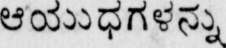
ಆಯುಧಗಳನ್ನು
